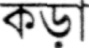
কড়া
